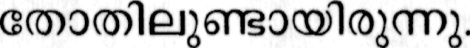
തോതിലുണ്ടായിരുന്നു.
